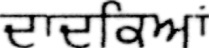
ਦਾਦਕਿਆਂ
